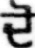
ਦੋ
